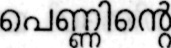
പെണ്ണിന്റെ
